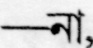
–না,
